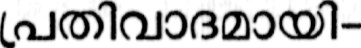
പ്രതിവാദമായി-
